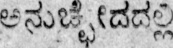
ಅನುಚ್ಛೇದದಲ್ಲಿ
